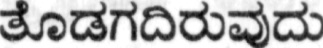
ತೊಡಗದಿರುವುದು
